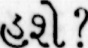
હશે?
